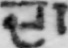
ਦਾ
